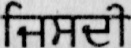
ਜਿਸਦੀ
